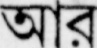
আর
